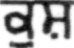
ਕੁਸ਼
